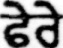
ਫੇਰੇ
